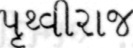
પૃથ્વીરાજ
